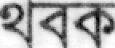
থবক
